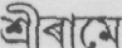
শ্রীৰামে
